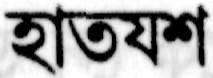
হাতযশ
